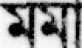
মমা
